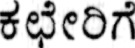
ಕಛೇರಿಗೆ
